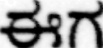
ಈಗ
